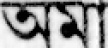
অমা
